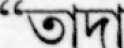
“তাদা
